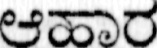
ಆಹಾರ
